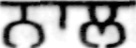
ਨਾਲ
